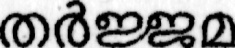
തര്‍ജ്ജമ
